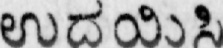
ಉದಯಿಸಿ
